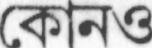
কোনও
